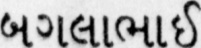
બગલાભાઈ
